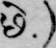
છે.)
